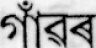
গাঁৱৰ
